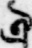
ঐ
